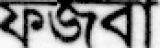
ফজবা
